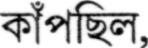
কাঁপছিল,
